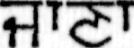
ਜਾਣਾ
